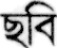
ছবি
